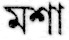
মশা
